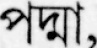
পদ্মা,
